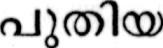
പുതിയ
